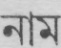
নাম
